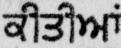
ਕੀਤੀਆਂ
